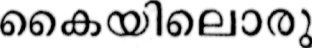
കൈയിലൊരു
